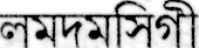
লমদমসিগী
